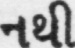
નથી
